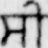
ਸੀ
